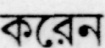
করেন
